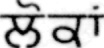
ਲੋਕਾਂ
